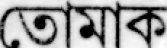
তোমাক
